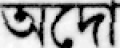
অদো
